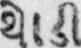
થોડી
